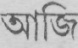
আজি
